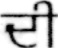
ਦੀ
